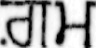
ਗ਼ਮ
